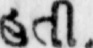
હતી.
